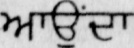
ਆਉਂਦਾ
